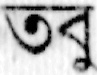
তবু
